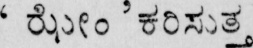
‘ಝೇಂ’ಕರಿಸುತ್ತ
